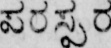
ಪರಸ್ಪರ
